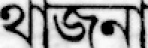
থাজনা
